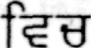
ਵਿਚ
